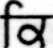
ਕਿ
